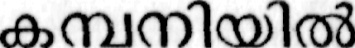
കമ്പനിയില്‍
